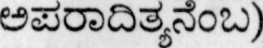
ಅಪರಾದಿತ್ಯನೆಂಬ)
